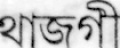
থাজগী
